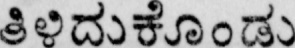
ತಿಳಿದುಕೊಂಡು
